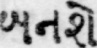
બનશે
